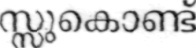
സ്സുകൊണ്ട്
